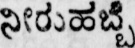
ನೀರುಹಬ್ಬೆ
